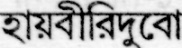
হায়বীরিদুবো
